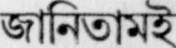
জানিতামই
